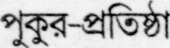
পুকুর-প্রতিষ্ঠা
